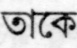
তাকে
